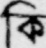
কি
